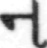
ન
